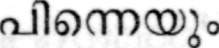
പിന്നെയും
